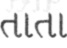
તાતા
